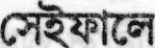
সেইফালে
